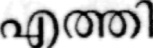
എത്തി
